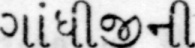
ગાંધીજીની
